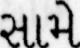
સામે
